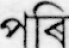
পৰি
